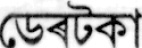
ডেৰটকা
